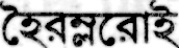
হৈরম্লরোই
